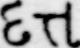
દત્ત
